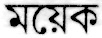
ময়েক
